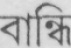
বান্ধি
